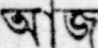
আজ
